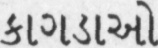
કાગડાઓ
